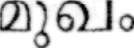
മുഖം
